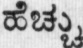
ಹೆಚ್ಚು
